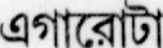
এগারোটা
